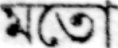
মতো
